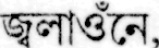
জ্বলাওঁনে,
